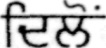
ਦਿਲੋਂ
